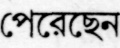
পেরেছেন
